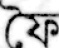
ফৈ
